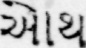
ઓથ
